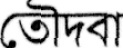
তৌদবা
